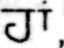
ਹਾਂ,
